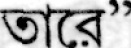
তারে”
